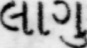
લાગુ
